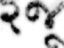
રજૂ
